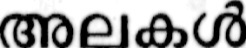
അലകള്‍
